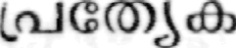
പ്രത്യേക
